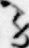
કે
